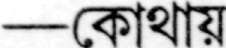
–কোথায়
